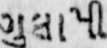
ગુલાપી
